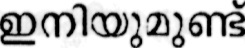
ഇനിയുമുണ്ട്
